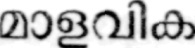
മാളവിക
